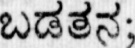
ಬಡತನ;
